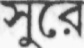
সুরে
